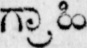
ಗ್ರಾಹಿ
